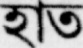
হাত
